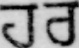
ਹਰ
